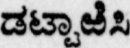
ಡಟ್ಟಾಱಸಿ
